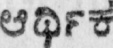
ಆರ್ಥಿಕ
